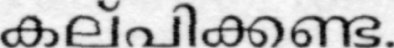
കല്പിക്കണ്ട.
